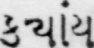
ક્યાંય
